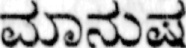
ಮಾನುಷ
